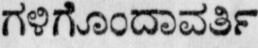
ಗಳಿಗೊಂದಾವರ್ತಿ
